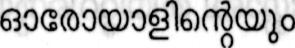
ഓരോയാളിന്റെയും
